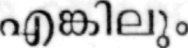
എങ്കിലും
